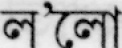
ল'লো
